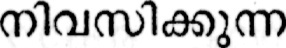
നിവസിക്കുന്ന
